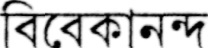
বিবেকানন্দ
